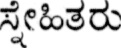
ಸ್ನೇಹಿತರು
